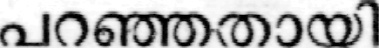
പറഞ്ഞതായി
